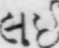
લઈ
